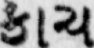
કાચ
